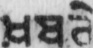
ਖ਼ਬਰੇ
